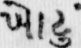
ખોટું
